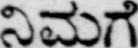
ನಿಮಗೆ
